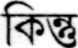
কিন্তু
